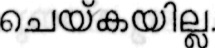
ചെയ്കയില്ല.
